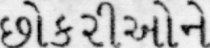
છોકરીઓને
